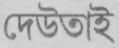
দেউতাই
